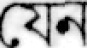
যেন
